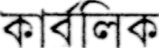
কার্বলিক
